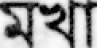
মখা
